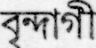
বৃন্দাগী
